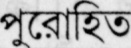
পুরোহিত
